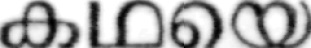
കഥയെ
